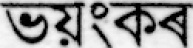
ভয়ংকৰ
